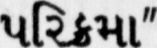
પરિક્રમા"
